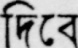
দিবে
